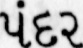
પંદર
